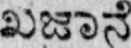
ಖಜಾನೆ
